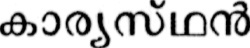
കാര്യസ്ഥന്‍
